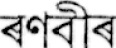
ৰণবীৰ
